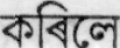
কৰিলে
